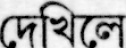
দেখিলে
